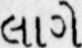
લાગે
